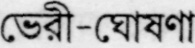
ভেরী-ঘোষণা
